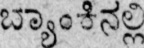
ಬ್ಯಾಂಕಿನಲ್ಲಿ
